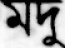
মদু
